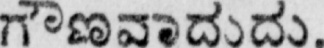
ಗೌಣವಾದುದು.
